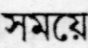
সময়ে
